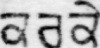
ਕਰਕੇ
